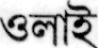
ওলাই
